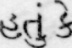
હતુંકે
